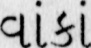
વાંકાં
